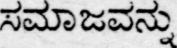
ಸಮಾಜವನ್ನು
